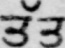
ਤੱਤ
